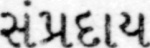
સંપ્રદાય
